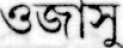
ওজাসু
